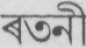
ৰতনী
